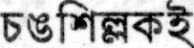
চঙশিল্লকই
